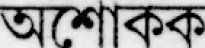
অশোকক
